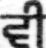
ਵੀ
